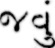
જવું
